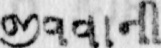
જીવવાની
